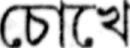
চোখে
